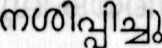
നശിപ്പിച്ചു
